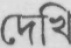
দেখি
